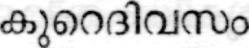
കുറെദിവസം
